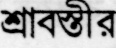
শ্রাবস্তীর
